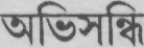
অভিসন্ধি
